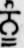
ਨੂੰ
